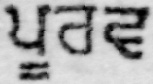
ਪੂਰਵ
